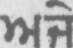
ਅਜੇ
